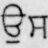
ਉਸ
